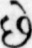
છે
